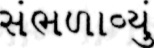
સંભળાવ્યું
